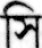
সি
